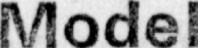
Model
